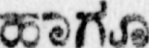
ಹಾಗೂ
